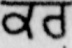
ਕਰ
